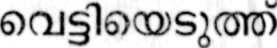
വെട്ടിയെടുത്ത്
